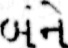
બંને
